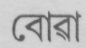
বোৱা
